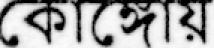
কোঙ্গোয়
